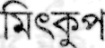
মিৎকুপ
